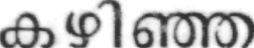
കഴിഞ്ഞ
